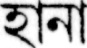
হানা
